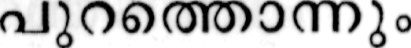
പുറത്തൊന്നും
